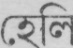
হেলি
